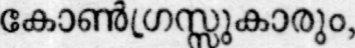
കോണ്‍ഗ്രസ്സുകാരും,
